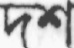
দশ
